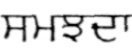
ਸਮਝਦਾ
